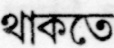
থাকতে
